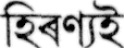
হিৰণ্যই
